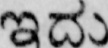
ಇದು
